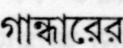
গান্ধারের
